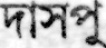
দাসপু
